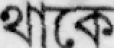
থাকে
